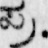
ಪ್ರ.
